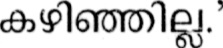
കഴിഞ്ഞില്ല.’
